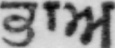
ਭਾਅ
